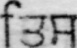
ਤਿਸ
